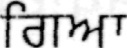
ਗਿਆ
